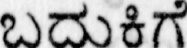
ಬದುಕಿಗೆ
